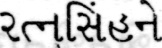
રત્નસિંહને
